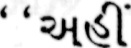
"અહીં
